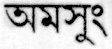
অমসুং
